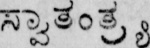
ಸ್ವಾತಂತ್ರ್ಯ
